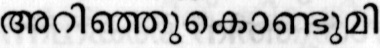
അറിഞ്ഞുകൊണ്ടുമി
